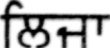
ਲਿਜਾ
